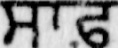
ਸਾਫ਼
